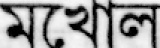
মখোল
